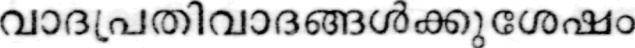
വാദപ്രതിവാദങ്ങള്‍ക്കുശേഷം
